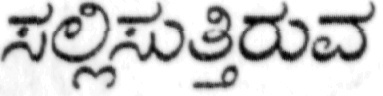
ಸಲ್ಲಿಸಿರುವ
